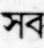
সব
